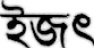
ইজৎ
